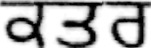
ਕਤਰ
